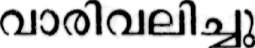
വാരിവലിച്ചു
